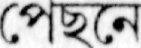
পেছনে
